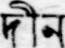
দীন
